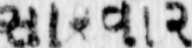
સારવાર
